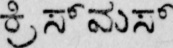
ಕ್ರಿಸ್‌ಮಸ್
